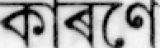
কাৰণে
